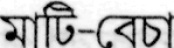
মাটি-বেচা
